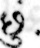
છું.
